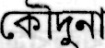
কৌদুনা
